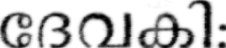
ദേവകി:
